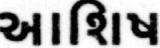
આશિષ
